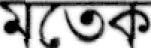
মতেক
